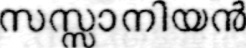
സസ്സാനിയന്‍
